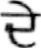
ਦੇ
